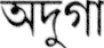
অদুগা
